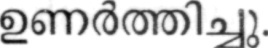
ഉണര്‍ത്തിച്ചു.
